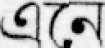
এনে
